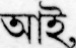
আই,
